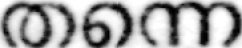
തന്നെ
